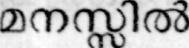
മനസ്സില്‍
